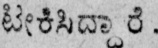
ಟೀಕಿಸಿದ್ದಾರೆ.
